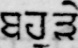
ਬਹੁੜੇ
